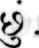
છું.
